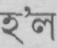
হ'ল
